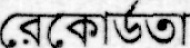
রেকোর্ডতা
